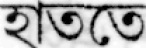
হাততে
